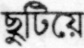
ছুটিয়ে
